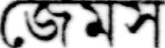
জেমস
